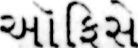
ઑફિસે
